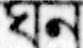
ঘন
